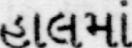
હાલમાં
